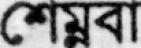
শেম্নবা
